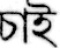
চাই
